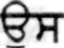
ਉਸ
